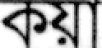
কয়া
